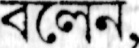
বলেন,
